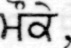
ਮੌਕੇ,
